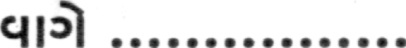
વાગે..........
